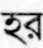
হর
